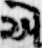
એ
